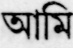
আমি
